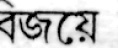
বিজয়ে
